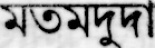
মতমদুদা
